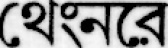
থেংনরে
